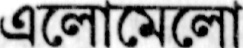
এলোমেলো
